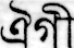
ঐগী
